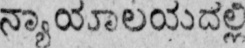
ನ್ಯಾಯಾಲಯದಲ್ಲಿ
